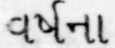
વર્ષના
